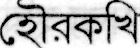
হৌরকখি
